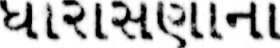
ધારાસણાના
